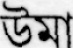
উমা
